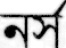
নর্স
